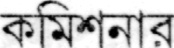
কমিশনার
